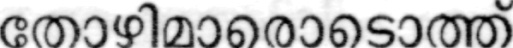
തോഴിമാരൊടൊത്ത്
